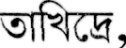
তাখিদ্রে,
